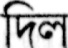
দিল
